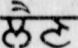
ਲੈਣ
